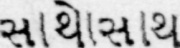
સાથોસાથ
